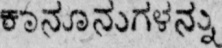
ಕಾನೂನುಗಳನ್ನು
